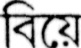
বিয়ে
